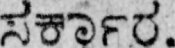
ಸರ್ಕಾರ.
